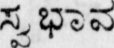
ಸ್ವಭಾವ
